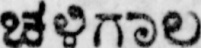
ಚಳಿಗಾಲ
